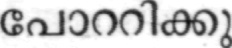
പോററിക്കു
